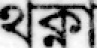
থক্না
